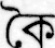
কৈ
